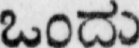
ಒಂದು
